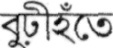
বুঢ়ীহঁতে
